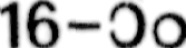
16-ാം
